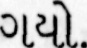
ગયો.
